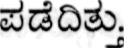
ಪಡೆದಿತ್ತು.
